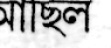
আছিল
